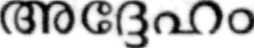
അദ്ദേഹം
